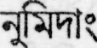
নুমিদাং
